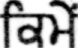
ਕਿਮੇਂ
